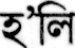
হ'লি
